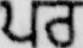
ਪਰ
